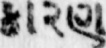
કારણ
